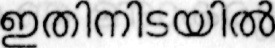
ഇതിനിടയില്‍
